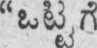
“ಒಟ್ಟಿಗೆ
